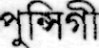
পুন্সিগী
